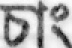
চাং
